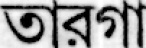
তারগা
